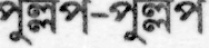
পুল্লপ-পুল্লপ
